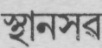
স্থানসৱ
